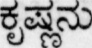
ಕೃಷ್ಣನು
